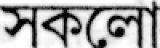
সকলো
